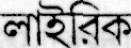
লাইরিক
